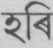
হৰি
